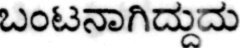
ಬಂಟನಾಗಿದ್ದುದು
